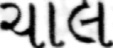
ચાલ
